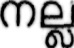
നല്ല
